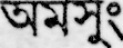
অমসুং
